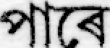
পাৰে
